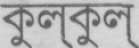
কুলকুল
